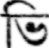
ভি
